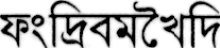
ফংদ্রিবমখৈদি
